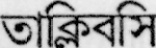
তাক্লিবসি
